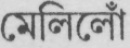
মেলিলোঁ
